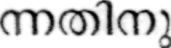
ന്നതിനു
